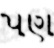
પણ
